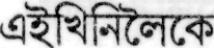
এইখিনিলৈকে
